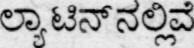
ಲ್ಯಾಟಿನ್‌ನಲ್ಲಿವೆ
